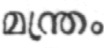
മന്ത്രം
